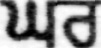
ਘਰ
